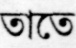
তাতে
